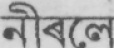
নীৰলে
